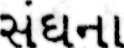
સંઘના
